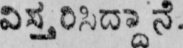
ವಿಸ್ತರಿಸಿದ್ದಾನೆ.
